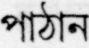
পাঠান
